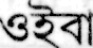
ওইবা
